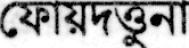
ফোয়দত্তুনা
